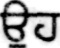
ਉਹ
